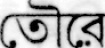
তৌরে
